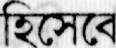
হিসেবে
